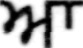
ਆ
